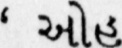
'ઓહ
